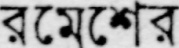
রমেশের
